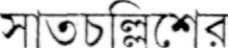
সাতচল্লিশের
